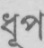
ধূপ
